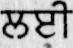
ਲਈ
